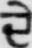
ਦੇ
